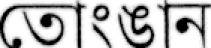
তোংঙান
